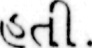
હતી.
